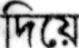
দিয়ে
